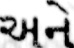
અને
